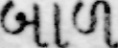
બાળ
